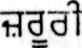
ਜ਼ਰੂਰੀ
